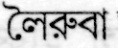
লৈরুবা
